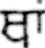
ਥਾਂ
